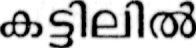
കട്ടിലില്‍
